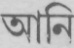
আনি
